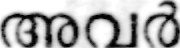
അവര്‍
